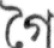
গৈ
